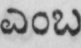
ಎಂಬ
